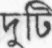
দুটি
